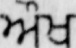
ਔਖ
